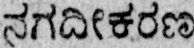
ನಗದೀಕರಣ
